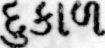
દુકાળ
